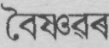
বৈষ্ণৱৰ
